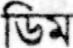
ডিম
